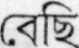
বেছি
